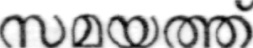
സമയത്ത്
